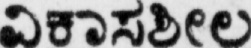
ವಿಕಾಸಶೀಲ
